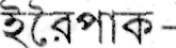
ইরৈপাক-
